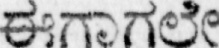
ಈಗಾಗಲೇ
